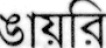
ঙায়রি
